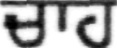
ਚਾਹ
